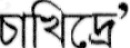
চাখিদ্রে’
